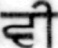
ਵੀ
